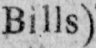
Bills)
